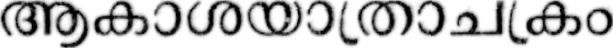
ആകാശയാത്രാചക്രം
